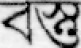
বস্তু
